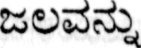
ಜಲವನ್ನು
